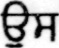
ਉਸ
